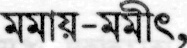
মমায়-মমীৎ,
